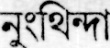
নুংথিন্দা
